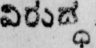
ವಿರುದ್ಧ
